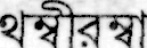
থম্বীরম্বা
